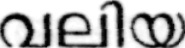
വലിയ
